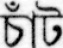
চাঁট
